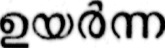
ഉയര്‍ന്ന
